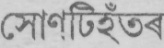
সোণটিহঁতৰ
